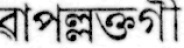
ৱাপল্লক্তগী
